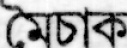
মৈচাক
